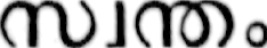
സ്വന്തം
